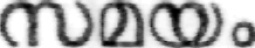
സമയം
